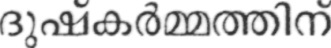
ദുഷ്കര്‍മ്മത്തിന്
